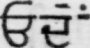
ਓਦੋਂ
